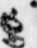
હું
